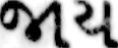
જાય
